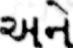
અને
